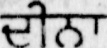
ਦੀਨਾ
